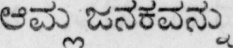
ಆಮ್ಲಜನಕವನ್ನು
